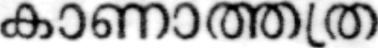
കാണാത്തത്ര
